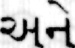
અને
